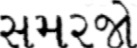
સમરજો
